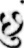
છું
